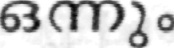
ഒന്നും
